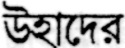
উহাদের
